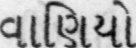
વાણિયો
